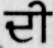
ਦੀ
